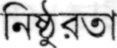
নিষ্ঠুরতা
